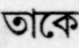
তাকে
